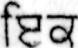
ਇਕ
